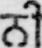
ਨੀ
